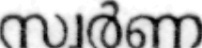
സ്വര്‍ണ
